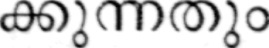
ക്കുന്നതും
